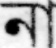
না
